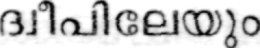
ദ്വീപിലേയും
